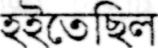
হইতেছিল
